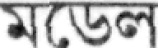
মডেল
